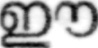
ഈ
